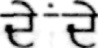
ਦੇਂਦੇ
